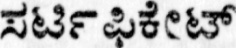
ಸರ್ಟಿಫಿಕೇಟ್
